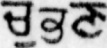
ਚੁਭਣ
